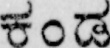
ಕಂಡ
